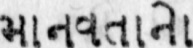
માનવતાનો
